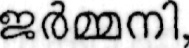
ജര്‍മ്മനി,
